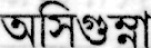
অসিগুম্না
